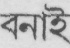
বনাই
